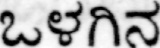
ಒಳಗಿನ
